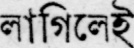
লাগিলেই
